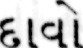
દાવો
